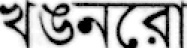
খঙনরো
